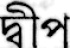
দ্বীপ
